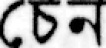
চেন
